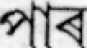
পাৰ
